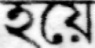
হয়ে
